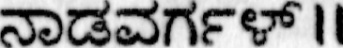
ನಾಡವರ್ಗಳ್|
